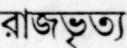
রাজভৃত্য
